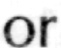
or
